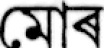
মোৰ
